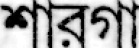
শারগা
